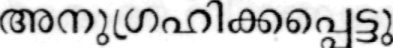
അനുഗ്രഹിക്കപ്പെട്ടു
